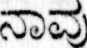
ನಾವು
